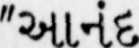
"આનંદ
